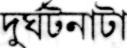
দুর্ঘটনাটা
